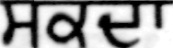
ਸਕਦਾ
